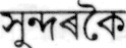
সুন্দৰকৈ
